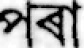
পৰা
